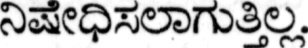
ನಿಷೇಧಿಸಲಾಗುತ್ತಿಲ್ಲ.
